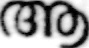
ആ
